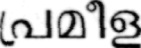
പ്രമീള
